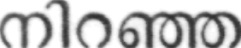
നിറഞ്ഞ
